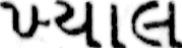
ખ્યાલ
